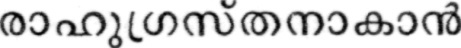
രാഹുഗ്രസ്തനാകാന്‍
